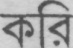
করি
